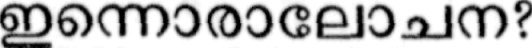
ഇന്നൊരാലോചന?
